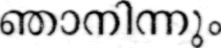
ഞാനിന്നും
